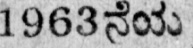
1963ನೆಯ
